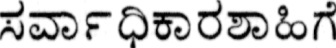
ಸರ್ವಾಧಿಕಾರಶಾಹಿಗೆ
